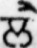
ਲੈ
